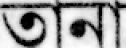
তানা
